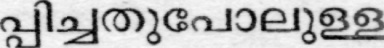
പ്പിച്ചതുപോലുള്ള
